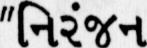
નિરંજન
